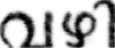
വഴി
